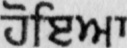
ਹੋਇਆ
